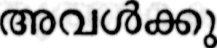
അവള്‍ക്കു
